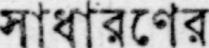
সাধারণের
